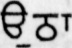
ਉਠਾ
